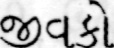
જીવકો
